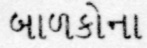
બાળકોના
